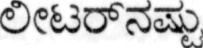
ಲೀಟರ್‌ನಷ್ಟು
